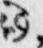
છે,
